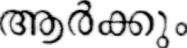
ആര്‍ക്കും
